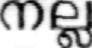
നല്ല
